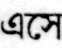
এসে
